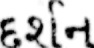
દર્શન
